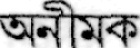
অনীমক
